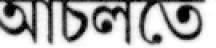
আচলতে
